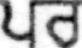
ਪਰ
